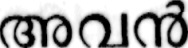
അവന്‍
